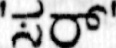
‘ಸರ್’
